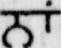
ਨਾਂ
